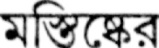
মস্তিষ্কের
